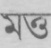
মত্ত
